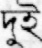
দুই
